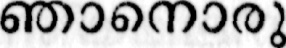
ഞാനൊരു
